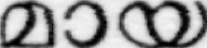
മായ
